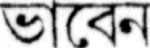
ভাবেন
